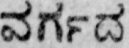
ವರ್ಗದ
